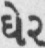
ઘેર
